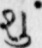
શું
